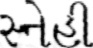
સ્નેહી
